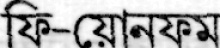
ফি-য়োনফম
